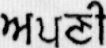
ਅਪਣੀ
